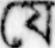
যে
